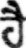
ਹੈ
